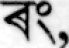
ৰং,
